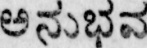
ಅನುಭವ
